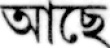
আছে
